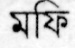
মফি
